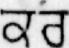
ਕਰ
